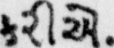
કરીએ.
